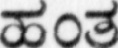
ಹಂತ
